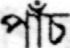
পাঁচ
